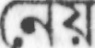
নেয়
